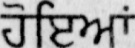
ਹੋਇਆਂ
